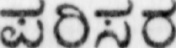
ಪರಿಸರ
